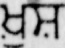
ਖ਼ੁਸ਼
